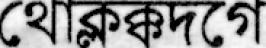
থোক্লক্কদগে
